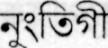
নুংতিগী
